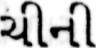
ચીની
